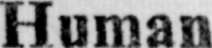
Human
